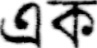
এক
